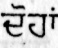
ਦੋਹਾਂ
